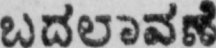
ಬದಲಾವಣೆ
